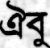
ঐবু
